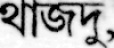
থাজদু,
